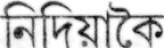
নিদিয়াকৈ
